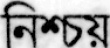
নিশ্চয়
